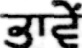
ਭਾਵੇਂ
